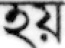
হয়
